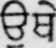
ਉਥੇ
